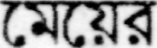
মেয়ের
